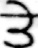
ਤੇ
